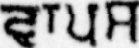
ਵਾਪਸ
